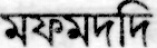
মফমদদি
